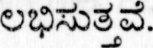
ಲಭಿಸುತ್ತವೆ.
